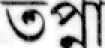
তপ্না
